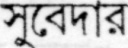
সুবেদার
